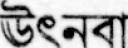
ঊৎনবা
